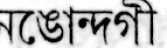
নঙোন্দগী
